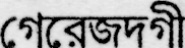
গেরেজদগী
